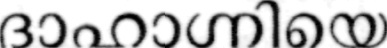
ദാഹാഗ്നിയെ
